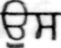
ਉਸ
